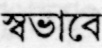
স্বভাবে
